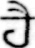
ਹੈ
